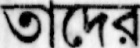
তাদের
